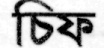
চিফ
